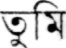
তুমি
